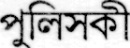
পুলিসকী
